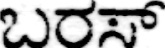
ಬರಸ್
